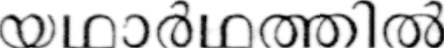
യഥാര്‍ഥത്തില്‍
